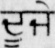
ਦੂਜੇ
